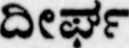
ದೀರ್ಘ
